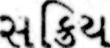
સક્રિય
